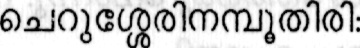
ചെറുശ്ശേരിനമ്പൂതിരി:
